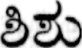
ಶಿಶು
